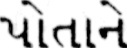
પોતાને
